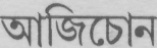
আজিচোন
